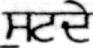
ਸੁਟਦੇ
